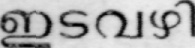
ഇടവഴി
